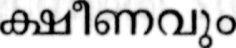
ക്ഷീണവും
